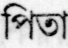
পিতা
